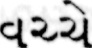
વચ્ચે
